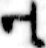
ન
